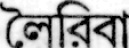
লৈরিবা
